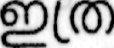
ഇത്ര
